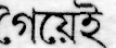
গৈয়েই
